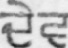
ਦੇਵ
